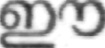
ഈ
